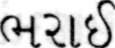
ભરાઈ
